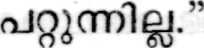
പറ്റുന്നില്ല.”
